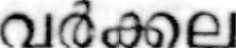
വര്‍ക്കല
